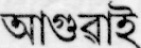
আগুৱাই
